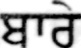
ਬਾਰੇ
